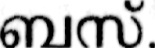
ബസ്.
